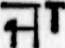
ਜਾ
